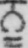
ਨੂ
